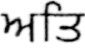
ਅਤਿ
